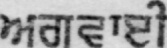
ਅਗਵਾਈ
